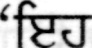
'ਇਹ
